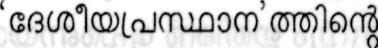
'ദേശീയപ്രസ്ഥാന'ത്തിന്റെ
